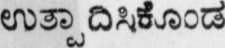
ಉತ್ಪಾದಿಸಿಕೊಂಡ
